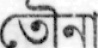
তৌনা
